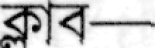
ক্লাব-
